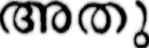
അതു
